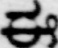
ಈ
